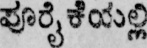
ಪೂರೈಕೆಯಲ್ಲಿ
